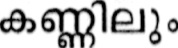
കണ്ണിലും
